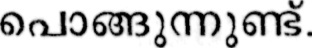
പൊങ്ങുന്നുണ്ട്.
